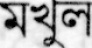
মখুল
